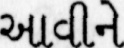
આવીને
